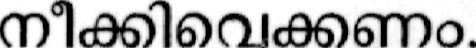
നീക്കിവെക്കണം.
